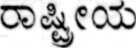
ರಾಷ್ಟ್ರೀಯ
